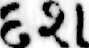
દશ
